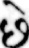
છે
